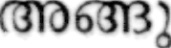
അങ്ങു
